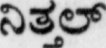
ನಿತ್ತಲ್
